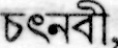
চৎনবী,
